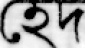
হেদ
